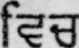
ਵਿਚ
